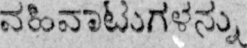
ವಹಿವಾಟುಗಳನ್ನು
